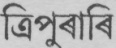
ত্ৰিপুৰাৰি
